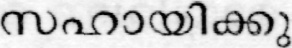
സഹായിക്കു
